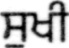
ਸੁਖੀ
